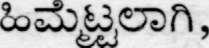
ಹಿಮ್ಮೆಟ್ಟಲಾಗಿ,
